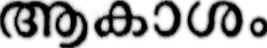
ആകാശം
